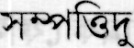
সম্পত্তিদু
